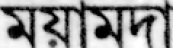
ময়ামদা
